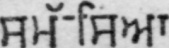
ਸਮੱਸਿਆ
